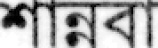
শান্নবা
